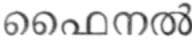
ഫൈനല്‍
